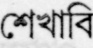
শেখাবি
